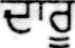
ਦਾਰੂ
